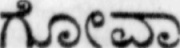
ಗೋವಾ
